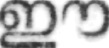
ഈ
